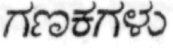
ಗಣಕಗಳು
